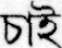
চাই
